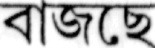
বাজছে
